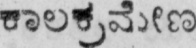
ಕಾಲಕ್ರಮೇಣ
